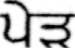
ਪੇੜ
